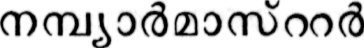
നമ്പ്യാര്‍മാസ്ററര്‍
